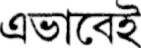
এভাবেই
